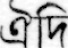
ঐদি
